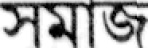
সমাজ
